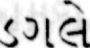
ડગલે
